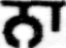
ਨਾ
